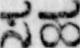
ಸಹ
